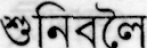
শুনিবলৈ
